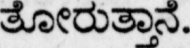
ತೋರುತ್ತಾನೆ.
